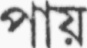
পায়
